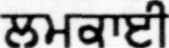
ਲਮਕਾਈ
